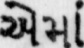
એમાં
